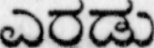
ಎರಡು
